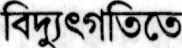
বিদ্যুৎগতিতে
